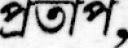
প্রতাপ,
